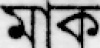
মাক
